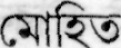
মোহিত
